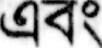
এবং
